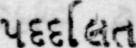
પદદલિત
